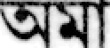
অমা
